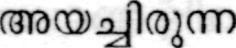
അയച്ചിരുന്ന
